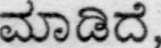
ಮಾಡಿದೆ,
